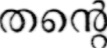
തന്റെ
